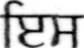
ਇਸ
